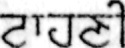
ਟਾਹਣੀ
